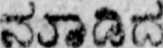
ಮಾಡಿದ
